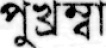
পুখ্রম্বা
